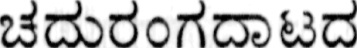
ಚದುರಂಗದಾಟದ
